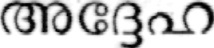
അദ്ദേഹ
